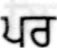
ਪਰ
